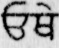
ਓਥੇ
